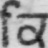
ਕਿ
